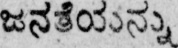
ಜನತೆಯನ್ನು
